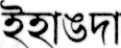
ইহাঙদা
